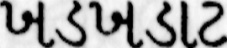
ખડખડાટ
